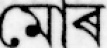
মোৰ
